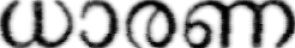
ധാരണ
